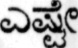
ಎಷ್ಟೇ
